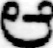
ಆ
